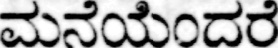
ಮನೆಯೆಂದರೆ
